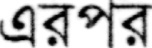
এরপর
